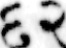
દર
